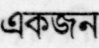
একজন
